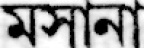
মসানা
